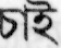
চাই
